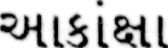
આકાંક્ષા
